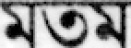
মতম
